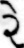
રે
